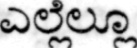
ಎಲ್ಲೆಲ್ಲೂ
